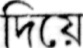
দিয়ে
